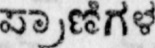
ಪ್ರಾಣಿಗಳ
